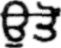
ਉਤੋਂ
